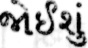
જોઈશું
